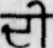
ਦੀ
